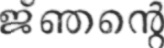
ജ്ഞന്റെ
